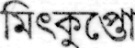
মিৎকুপ্তো
